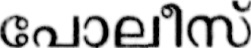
പോലീസ്
